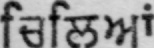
ਚਿਲਿਆਂ
